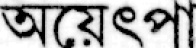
অয়েৎপা
